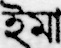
ইমা
